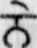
ਨੇ
